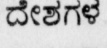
ದೇಶಗಳ
